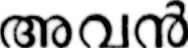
അവന്‍
